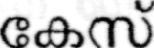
കേസ്
